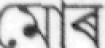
মোৰ
